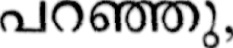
പറഞ്ഞു,
